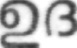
ഉദ
